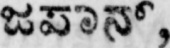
ಜಪಾನ್,
